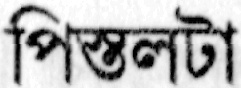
পিস্তলটা
